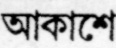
আকাশে
